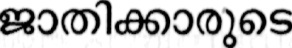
ജാതിക്കാരുടെ
